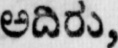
ಅದಿರು,
